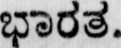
ಭಾರತ.
